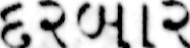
દરબાર
